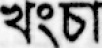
খংচা
